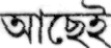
আছেই
